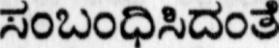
ಸಂಬಂಧಿಸಿದಂತೆ
